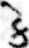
કે
